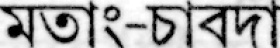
মতাং-চাবদা
